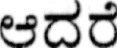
ಆದರೆ
